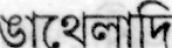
ঙাথেলাদি
